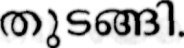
തുടങ്ങി.
